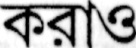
করাও
